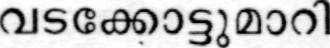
വടക്കോട്ടുമാറി
